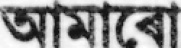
আমাৰো
